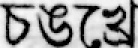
চঙখ্রে
